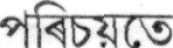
পৰিচয়তে
